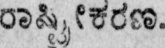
ರಾಷ್ಟ್ರೀಕರಣ.
